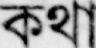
কথা
